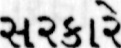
સરકારે
